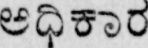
ಅಧಿಕಾರ
